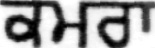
ਕਮਰਾ
